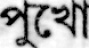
পুখো
